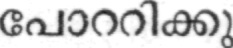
പോററിക്കു
